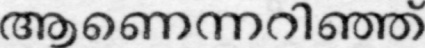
ആണെന്നറിഞ്ഞ്
